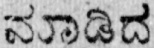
ಮಾಡಿದ
